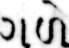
ગળે
